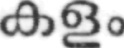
കളം
